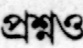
প্রশ্নও
